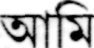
আমি
